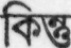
কিন্তু
